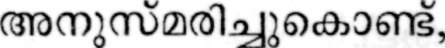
അനുസ്മരിച്ചുകൊണ്ട്,
